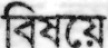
বিষয়ে
